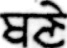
ਬਣੇ
